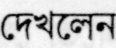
দেখলেন
